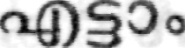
എട്ടാം
